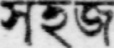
সহজ
